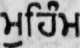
ਮੁਹਿੰਮ
